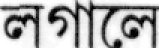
লগালে
